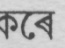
কৰে
